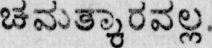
ಚಮತ್ಕಾರವಲ್ಲ.
